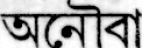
অনৌবা
